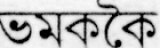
ভমককৈ
